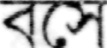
বসে
